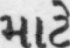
માટે
